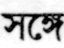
সঙ্গে
